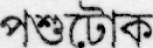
পশুটোক
